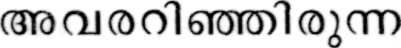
അവരറിഞ്ഞിരുന്ന
